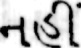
નહીં
